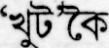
'খুট'কৈ
